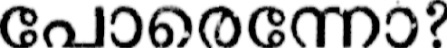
പോരെന്നോ?
